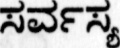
ಸರ್ವಸ್ಯ
